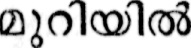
മുറിയില്‍
